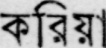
করিয়া
